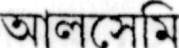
আলসেমি
